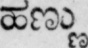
ಹಣ್ಣು
